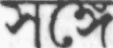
সঙ্গে
